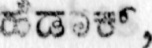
ಹೆಡಾಕ್,
